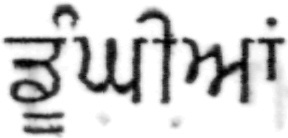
ਡੂੰਘੀਆਂ
